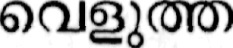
വെളുത്ത
